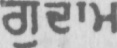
ਗੁਦਾਮ
